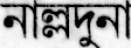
নাল্লদুনা
